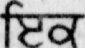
ਇਕ
